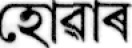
হোৱাৰ
